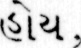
હોય,
